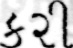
કરી
